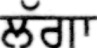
ਲੱਗਾ
